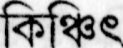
কিঞ্চিৎ
